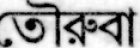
তৌরুবা
